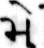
મેં
